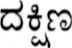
ದಕ್ಷಿಣ
